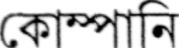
কোম্পানি
